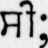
ਸੀ;
